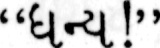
"ધન્ય!"
